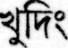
খুদিং
